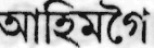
আহিমগৈ
